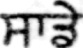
ਸਾਡੇ
